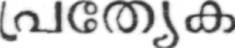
പ്രത്യേക
